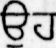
ਉਹ
